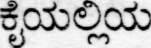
ಕೈಯಲ್ಲಿಯ
